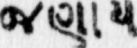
જણાય
